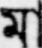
মা
